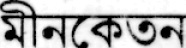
মীনকেতন
